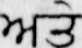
ਅਤੇ
